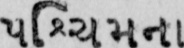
પશ્ચિમના
